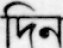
দিন
